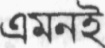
এমনই
